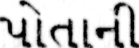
પોતાની
